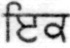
ਇਕ
